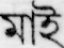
মাই
